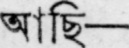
আছি—
